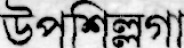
উপশিল্লগা
